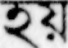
হয়
